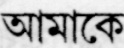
আমাকে
